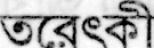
তরেৎকী
